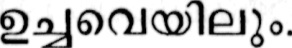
ഉച്ചവെയിലും.
